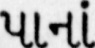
પાનાં
